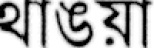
থাঙয়া
